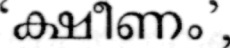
'ക്ഷീണം',
